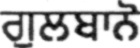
ਗੁਲਬਾਨੋ
